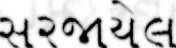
સરજાયેલા
